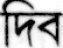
দিব
